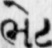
ભેટ
